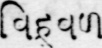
વિહવળ
